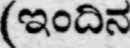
(ಇ೦ದಿನ
